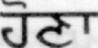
ਹੋਣਾ
